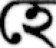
হে
